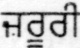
ਜ਼ਰੂਰੀ
